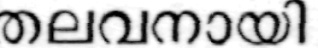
തലവനായി
